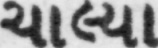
ચાલ્યા
